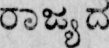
ರಾಜ್ಯದ
